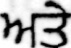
ਅਤੇ
